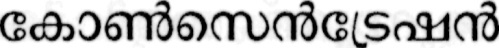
കോണ്‍സെന്‍ട്രേഷന്‍
